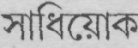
সাধিয়োক
